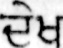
ਦੇਖ
